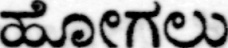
ಹೋಗಲು
